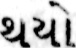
થયો
